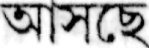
আসছে
